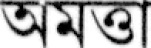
অমত্তা
